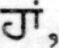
ਹਾਂ,
